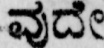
ವುದೇ
